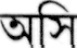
অসি
